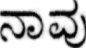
ನಾವು
